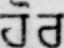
ਹੋਰ
